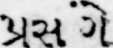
પ્રસંગે
